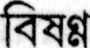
বিষণ্ণ
